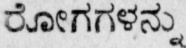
ರೋಗಗಳನ್ನು
